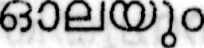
ഓലയും
